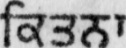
ਕਿਤਨਾ
